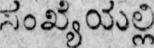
ಸಂಖ್ಯೆಯಲ್ಲಿ
